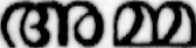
അമ്മ
